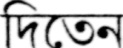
দিতেন
